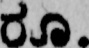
ರೂ.
